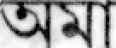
অমা
